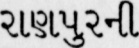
રાણપુરની
